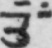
ਤੋਂ
